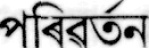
পৰিৱর্তন
